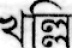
খল্লি
